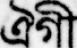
ঐগী
